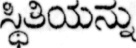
ಸ್ಥಿತಿಯನ್ನು
